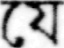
যে
